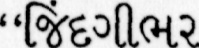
"જિંદગીભર
